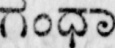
ಗಂಧಾ
